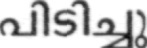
പിടിച്ചു
